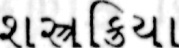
શસ્ત્રક્રિયા
